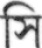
সি
